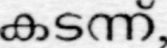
കടന്ന്,
